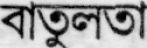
বাতুলতা
